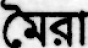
মৈরা
